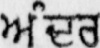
ਅੰਦਰ
